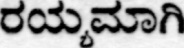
ರಯ್ಯಮಾಗಿ
